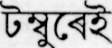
টম্বুৰেই
